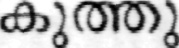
കുത്തു
